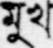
মুখ
